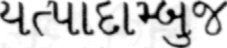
યત્પાદામ્બુજ
